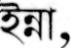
ইন্না,
